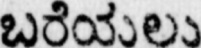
ಬರೆಯಲು
